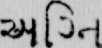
અગ્નિ
